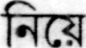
নিয়ে
